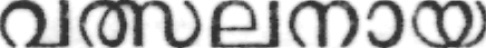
വത്സലനായ
